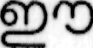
ഈ
